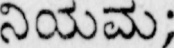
ನಿಯಮ;
